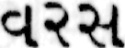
વરસ
